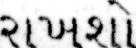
રાખશો
